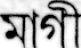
মাগী
